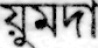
য়ুমদা
